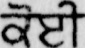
ਕੋਈ
